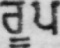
ਰੂਪ
